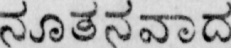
ನೂತನವಾದ
